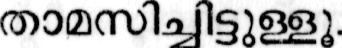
താമസിച്ചിട്ടുള്ളൂ.
